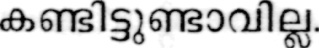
കണ്ടിട്ടുണ്ടാവില്ല.
